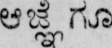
ಆಜ್ಞೆಗೂ
